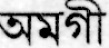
অমগী
